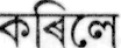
কৰিলে
